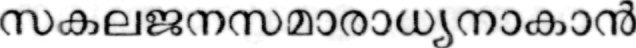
സകലജനസമാരാധ്യനാകാന്‍
